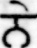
ਨੇ
